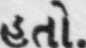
હતો.
